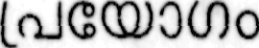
പ്രയോഗം
